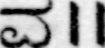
ವ||
